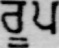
ਰੂਪ
